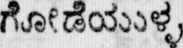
ಗೋಡೆಯುಳ್ಳ
